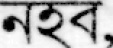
নহব,
